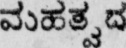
ಮಹತ್ವದ
